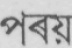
পৰয়
